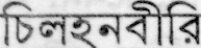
চিলহনবীরি
